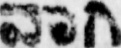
ವಾಗಿ
